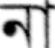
না
